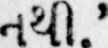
નથી.'
